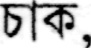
চাক,
